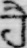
ਹੈ
